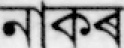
নাকৰ
